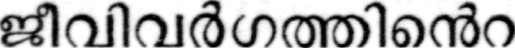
ജീവിവര്‍ഗത്തിന്റെ
